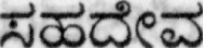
ಸಹದೇವ
